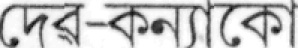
দেৱ-কন্যাকো
